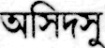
অসিদসু
